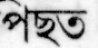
পিছত
